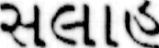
સલાહ
